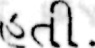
હતી.
